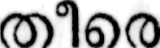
തീരെ
